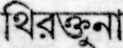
থিরক্তুনা
